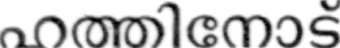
ഹത്തിനോട്
